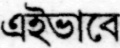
এইভাবে
